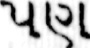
પણ
